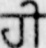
ਹੀ
